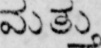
ಮತ್ತು
